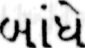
બાંધે
